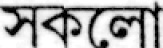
সকলো
